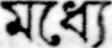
মধ্যে
